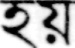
হয়
